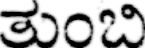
ತುಂಬಿ
